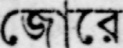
জোরে
